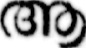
ആ
